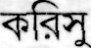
করিসু
